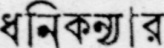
ধনিকন্যার
